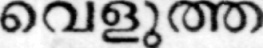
വെളുത്ത
